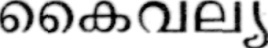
കൈവല്യ
